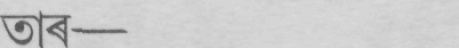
তাৰ-
